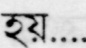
হয়....
